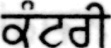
ਕੰਟਰੀ
